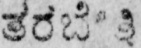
ತರಬೇತಿ
